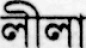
লীলা
